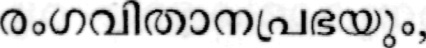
രംഗവിതാനപ്രഭയും,
